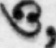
ও,
